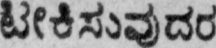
ಟೀಕಿಸುವುದರ
